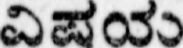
ವಿಷಯ
